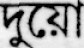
দুয়ো
